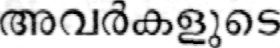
അവര്‍കളുടെ
